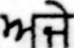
ਅਜੇ
